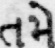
તમે
